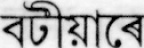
বটীয়াৰে
